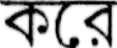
করে
